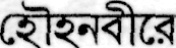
হৌহনবীরে
